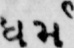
ધર્મ
